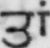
ਤਾਂ
